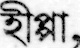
হীপ্পা,
